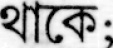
থাকে;
